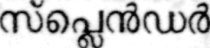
സ്പ്ലെന്‍ഡര്‍
